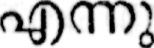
എന്നു
